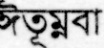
ঈতূম্নবা
